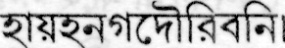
হায়হনগদৌরিবনি।
